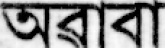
অৱাবা
